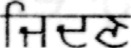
ਜਿਦਣ
